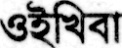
ওইখিবা
